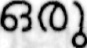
ഒരു
